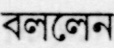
বললেন
